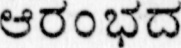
ಆರಂಭದ
